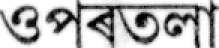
ওপৰতলা
